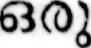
ഒരു
